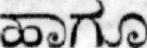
ಹಾಗೂ
